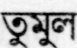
তুমুল
